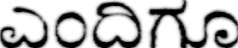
ಎಂದಿಗೂ
